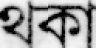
থকা
